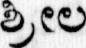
ಶ್ರೀಲ
